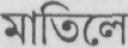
মাতিলে
